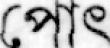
পোৎ
